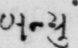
બન્યું
